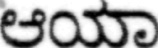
ಆಯಾ
